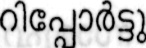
റിപ്പോര്‍ട്ടു
